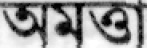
অমত্তা
